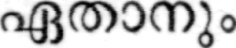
ഏതാനും
